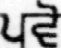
ਪਵੋ
